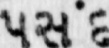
પસંદ
